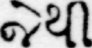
જેથી
